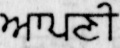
ਆਪਣੀ
